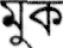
মুক
